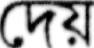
দেয়
